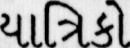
યાત્રિકો
